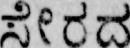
ಸೇರದ
